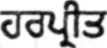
ਹਰਪ੍ਰੀਤ
